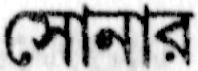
সোনার
